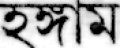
হঙ্গাম
